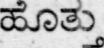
ಹೊತ್ತು
